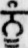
ਨੂੰ
